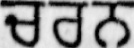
ਚਰਨ
